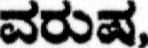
ವರುಷ,
